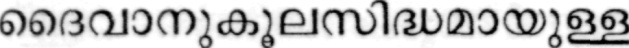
ദൈവാനുകൂലസിദ്ധമായുള്ള
